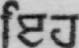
ਇਹ
